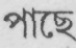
পাছে
